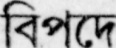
বিপদে
